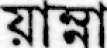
য়াম্না
